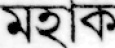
মহাক
